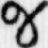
જ
